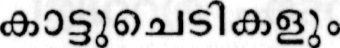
കാട്ടുചെടികളും
